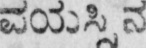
ವಯಸ್ಸಿನ
